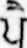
ਪੈ
